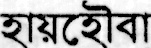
হায়হৌবা
